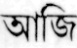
আজি
